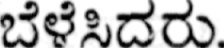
ಬೆಳೆಸಿದರು.
